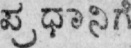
ಪ್ರಧಾನಿಗೆ
